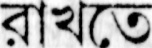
রাখতে
